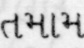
તમામ
